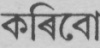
কৰিবো
